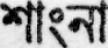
শাংনা
